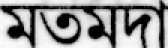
মতমদা
